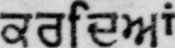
ਕਰਦਿਆਂ
